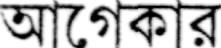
আগেকার
